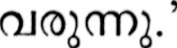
വരുന്നു.’
